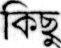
কিছু
